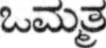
ಒಮ್ಮತ
